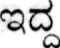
ಇದ್ದ
